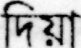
দিয়া
